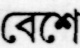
বেশে
